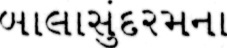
બાલાસુંદરમના
